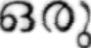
ഒരു
